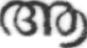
ആ
